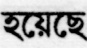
হয়েছে
